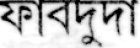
ফাবদুদা
